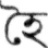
হৈ
